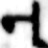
ન
